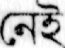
নেই
